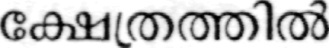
ക്ഷേത്രത്തില്‍
